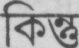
কিন্তু
